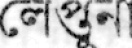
লেপ্তুনা
